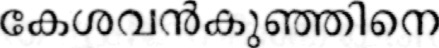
കേശവന്‍കുഞ്ഞിനെ
